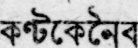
কণ্টকেনৈব
